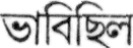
ভাবিছিল
